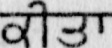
ਕੀਤਾ
